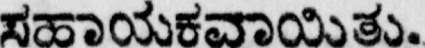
ಸಹಾಯಕವಾಯಿತು.
